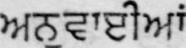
ਅਨੁਵਾਈਆਂ
